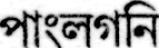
পাংলগনি
